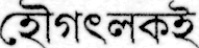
হৌগৎলকই
